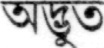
অদ্ভুত
